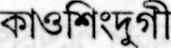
কাওশিংদুগী
